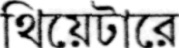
থিয়েটারে
